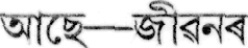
আছে-জীৱনৰ
